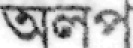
অলপ
